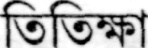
তিতিক্ষা
